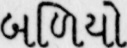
બળિયો
